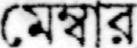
মেম্বার
